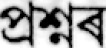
প্রশ্নৰ
